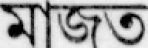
মাজত
